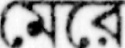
মেরে
